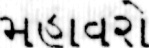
મહાવરો
